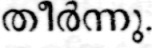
തീര്‍ന്നു.
